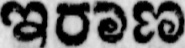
ಇರಾಣ
